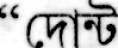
“দোন্ট
